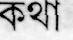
কথা
